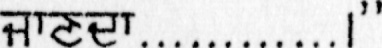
ਜਾਣਦਾ.............।''
